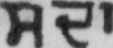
ਸਦਾ
